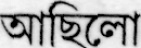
আছিলো
